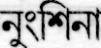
নুংশিনা
